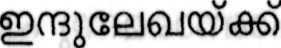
ഇന്ദുലേഖയ്ക്ക്
